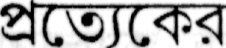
প্রত্যেকের
